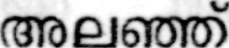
അലഞ്ഞ്
